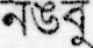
নঙবু
